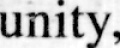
unity,
